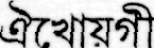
ঐখোয়গী
